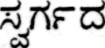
ಸ್ವರ್ಗದ
